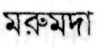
মরুমদা
